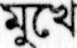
মুখে
